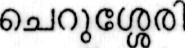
ചെറുശ്ശേരി
